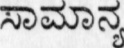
ಸಾಮಾನ್ಯ
